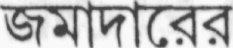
জমাদারের
